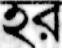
হর
